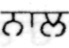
ਨਾਲ
